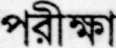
পরীক্ষা
